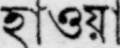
হাওয়া
